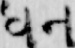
ધન
